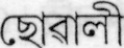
ছোৱালী
